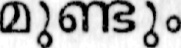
മുണ്ടും
